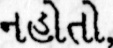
નહોતો,
